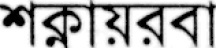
শক্নায়রবা
